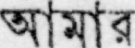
আমার
